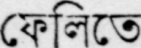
ফেলিতে
